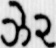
ઝેર
